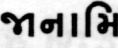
જાનામિ
